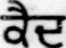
ਕੈਦ
